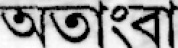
অতাংবা
